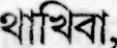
থাখিবা,
